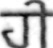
ਹੀ
